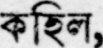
কহিল,
